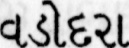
વડોદરા
